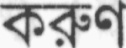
করুণ
